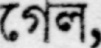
গেল,
